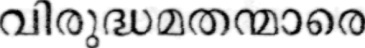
വിരുദ്ധമതന്മാരെ
